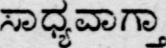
ಸಾಧ್ಯವಾಗ್ತಾ
